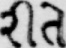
રીતે
